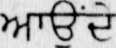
ਆਉਂਦੇ
